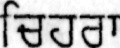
ਚਿਹਰਾ
